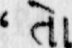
'તો
